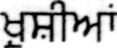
ਖ਼ੁਸ਼ੀਆਂ
